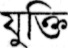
যুক্তি
